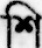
শি
